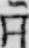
ਸੋ
